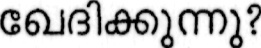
ഖേദിക്കുന്നു?
